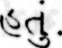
હતું.
